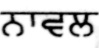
ਨਾਵਲ
